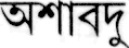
অশাবদু
